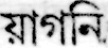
য়াগনি
